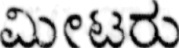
ಮೀಟರು
